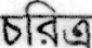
চরিত্র
